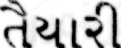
તૈયારી
